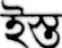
ইস্ত
